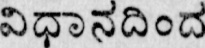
ವಿಧಾನದಿಂದ
